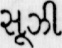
સૂઝી
